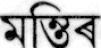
মন্তিৰ
